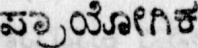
ಪ್ರಾಯೋಗಿಕ
